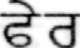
ਫੇਰ
